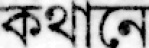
কথানে
